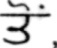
ਤੋਂ,
